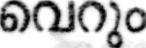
വെറും
